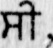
ਸੀ,
